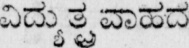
ವಿದ್ಯುತ್ಪ್ರವಾಹದ
